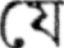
যে
